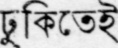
ঢুকিতেই
